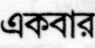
একবার
